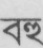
বহু
